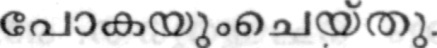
പോകയുംചെയ്തു.
